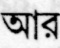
আর
